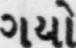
ગયો
